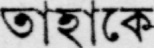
তাহাকে
